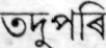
তদুপৰি
